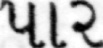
પાર
